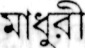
মাধুরী
